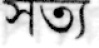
‘সত্য
